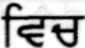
ਵਿਚ
